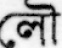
লৌ
